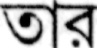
তার
